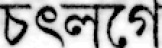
চৎলগে
